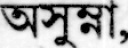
অসুম্না,
